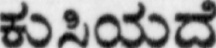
ಕುಸಿಯದೆ
